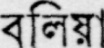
বলিয়া
